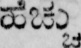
ಹೆಚ್ಚು
